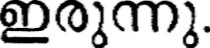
ഇരുന്നു.
